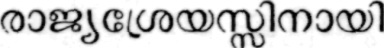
രാജ്യശ്രേയസ്സിനായി
